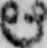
ಆ
